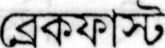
ব্রেকফাস্ট
